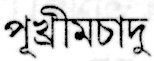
পূখ্রীমচাদু
